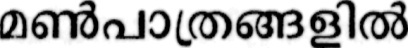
മണ്‍പാത്രങ്ങളില്‍
